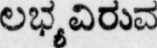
ಲಭ್ಯವಿರುವ
